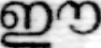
ഈ
